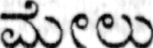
ಮೇಲು
